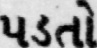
પડતો
